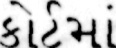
કોર્ટમાં
